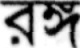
রঙ্গ
